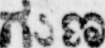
ಗುಣ
